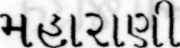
મહારાણી
